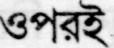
ওপরই
